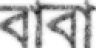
বাবা
